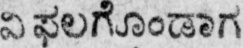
ವಿಫಲಗೊಂಡಾಗ
